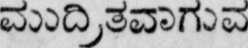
ಮುದ್ರಿತವಾಗುವ
